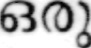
ഒരു
